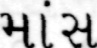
માંસ
